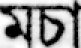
মচা
